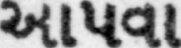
આપવા
